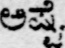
ಅಷ್ಟೆ
